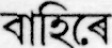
বাহিৰে
